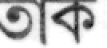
তাক
